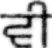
ਵੀ
